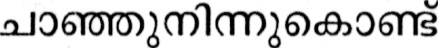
ചാഞ്ഞുനിന്നുകൊണ്ട്
